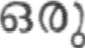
ഒരു
